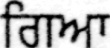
ਗਿਆ
